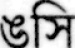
ঙসি
